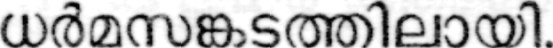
ധര്‍മസങ്കടത്തിലായി.
